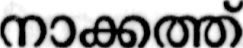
നാക്കത്ത്
